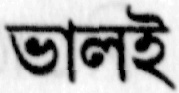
ভালই
